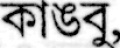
কাঙবু,
